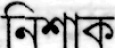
নিশাক
